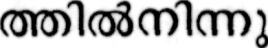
ത്തില്‍നിന്നു
